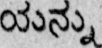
ಯನ್ನು
